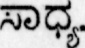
ಸಾಧ್ಯ.
